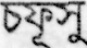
চফূসু
